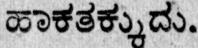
ಹಾಕತಕ್ಕುದು.
